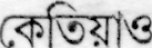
কেতিয়াও
